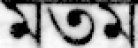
মতম
